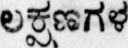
ಲಕ್ಷಣಗಳ
